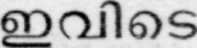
ഇവിടെ
